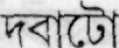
দবাটো
